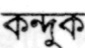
কন্দুক
